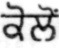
ਕੋਲੋਂ
